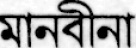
মানবীনা
